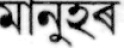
মানুহৰ
